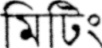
মিটিং
